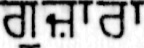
ਗੁਜ਼ਾਰਾ
